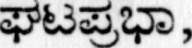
ಘಟಪ್ರಭಾ,
